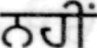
ਨਹੀਂ
